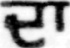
ਦਾ
